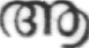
ആ
